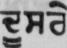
ਦੂਸਰੇ
